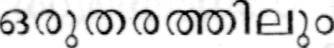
ഒരുതരത്തിലും
